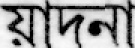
য়াদনা
